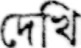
দেখি
